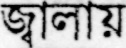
জ্বালায়
